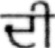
ਦੀ
